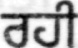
ਰਹੀ
